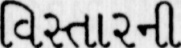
વિસ્તારની
